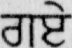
ਗਏ
